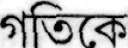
গতিকে
